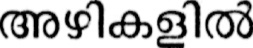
അഴികളില്‍
